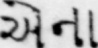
એના
